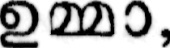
ഉമ്മാ,
